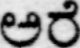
ಅರೆ
